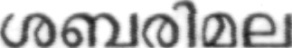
ശബരിമല
